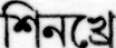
শিনখ্রে
